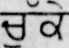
ਚੁੱਕੇ
